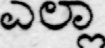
ಎಲ್ಲಾ
